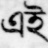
এই
